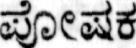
ಪೋಷಕ
